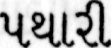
પથારી
